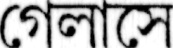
গেলাসে
